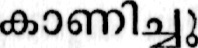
കാണിച്ചു
